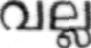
വല്ല
